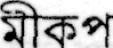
মীকপ
